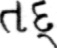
તદ્
